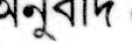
অনুবাদ
